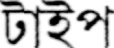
টাইপ
